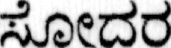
ಸೋದರ
